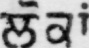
ਲੋਕਾਂ
